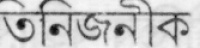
তিনিজনীক
